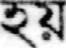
হয়
